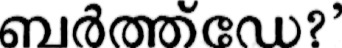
ബര്‍ത്ത്ഡേ?'
